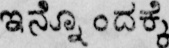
ಇನ್ನೊಂದಕ್ಕೆ
